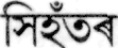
সিহঁতৰ
